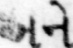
અને
